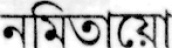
নমিতায়ো
